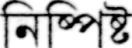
নিষ্পিষ্ট
